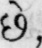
છે,
